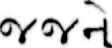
જજને
